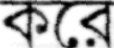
করে
